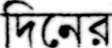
দিনের
